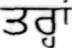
ਤਰ੍ਹਾਂ
